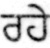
ਰਹੇ
